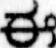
ಈ
